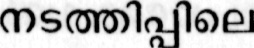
നടത്തിപ്പിലെ
